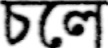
চলে
